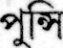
পুন্সি
